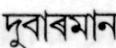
দুবাৰমান
